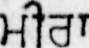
ਮੀਰਾ
